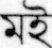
মই
